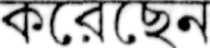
করেছেন
